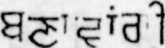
ਬਣਾਵਾਂਗੀ
